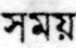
সময়
